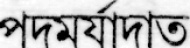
পদমর্যাদাত
